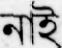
নাই
